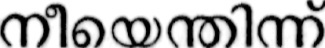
നീയെന്തിന്ന്
